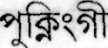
পুক্নিংগী
